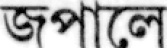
জপালে
